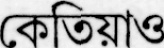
কেতিয়াও
